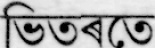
ভিতৰতে
